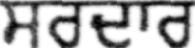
ਸਰਦਾਰ
